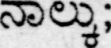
ನಾಲ್ಕು;
